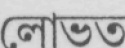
লোভত
